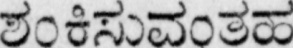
ಶಂಕಿಸುವಂತಹ
